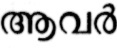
ആവര്‍
